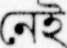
নেই
